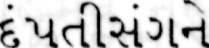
દંપતીસંગને
